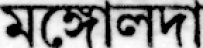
মঙ্গোলদা
